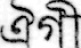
ঐগী
